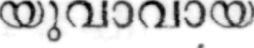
യുവാവായ
